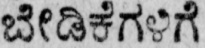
ಬೇಡಿಕೆಗಳಿಗೆ
